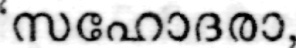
‘സഹോദരാ,
